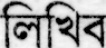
লিখিব
